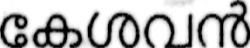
കേശവന്‍
